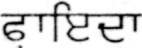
ਫ਼ਾਇਦਾ
